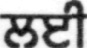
ਲਈ
